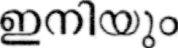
ഇനിയും
